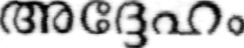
അദ്ദേഹം
